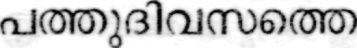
പത്തുദിവസത്തെ
